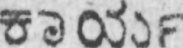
ಕಾರ್ಯ
